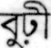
বুঢ়ী
